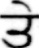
ਤੇ
